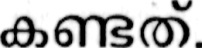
കണ്ടത്.
